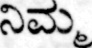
ನಿಮ್ಮ
